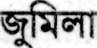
জুমিলা
